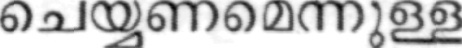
ചെയ്യണമെന്നുള്ള
